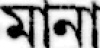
মানা
